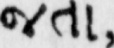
જતા,
